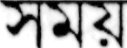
সময়
